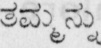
ತಮ್ಮನ್ನು
